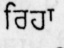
ਰਿਹਾ
